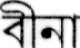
বীনা
